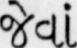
જેવાં
